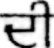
ਦੀ
